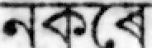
নকৰে
